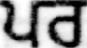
ਪਰ
